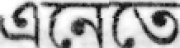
এনেতে
